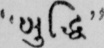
“બુદ્ધિ”
